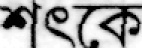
শৎকে
